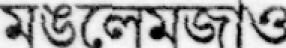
মঙলেমজাও
